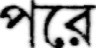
পরে
